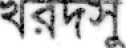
খরদসু
